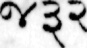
જરૂર
